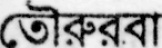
তৌরুরবা
